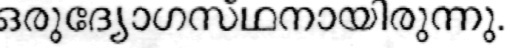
ഒരുദ്യോഗസ്ഥനായിരുന്നു.
